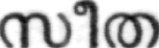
സീത
